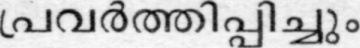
പ്രവര്‍ത്തിപ്പിച്ചും
